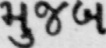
મુજબ
